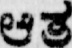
ಆತ
